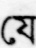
যে
